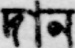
দান
